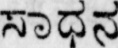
ಸಾಧನ
